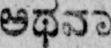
ಅಥವಾ
